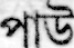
পাউ
